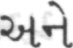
અને
